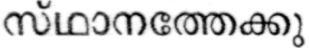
സ്ഥാനത്തേക്കു
